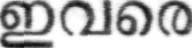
ഇവരെ
